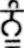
ਨੂੰ
